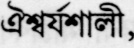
ঐশ্বর্যশালী,
